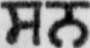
ਸਨ
